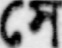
সে
